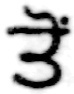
ਤੋਂ
